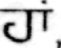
ਹਾਂ,
